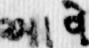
આવે
